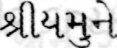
શ્રીયમુને
